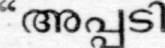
"അപ്പടി
